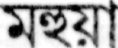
মহুয়া
